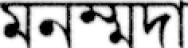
মনম্মদা
